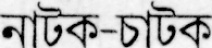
নাটক-চাটক
